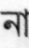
না
